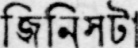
জিনিসটা
